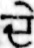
ਦੇ
